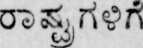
ರಾಷ್ಟ್ರಗಳಿಗೆ
